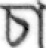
চা
